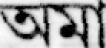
অমা
